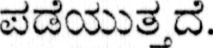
ಪಡೆಯುತ್ತದೆ.
